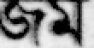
জম
